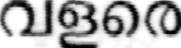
വളരെ
